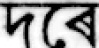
দৰে
